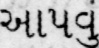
આપવું
